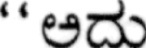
"ಅದು
